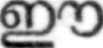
ഈ
